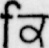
ਕਿ
